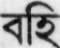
বহি
